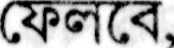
ফেলবে,
